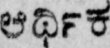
ಆರ್ಥಿಕ
